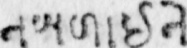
નબળાઈને
